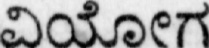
ವಿಯೋಗ
